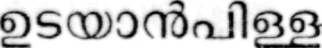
ഉടയാന്‍പിള്ള
